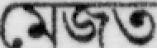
মেজত
